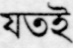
যতই
